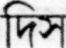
দিস
